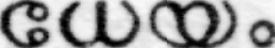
ധേയം
